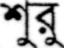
শুরু
